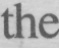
the
